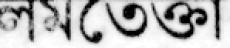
লমতেক্তা
